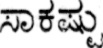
ಸಾಕಷ್ಟು
